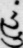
હું
